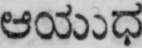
ಆಯುಧ
